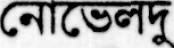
নোভেলদু
